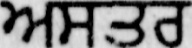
ਅਸਤਰ
